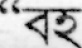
"বহ
